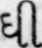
ઘી
